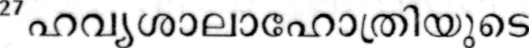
27ഹവ്യശാലാഹോത്രിയുടെ
